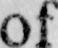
of
